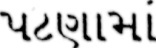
પટણામાં
